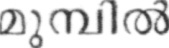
മുമ്പില്‍
